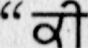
''ਕੀ
